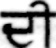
ਦੀ
